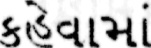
કહેવામાં
